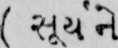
(સૂર્યને
